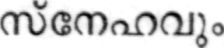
സ്നേഹവും
